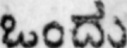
ಒಂದು
